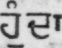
ਹੁੰਦਾ
